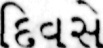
દિવસે
